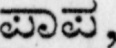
ಪಾಪ,
